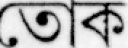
তোক
